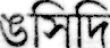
ঙসিদি
